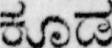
ಕೂಡ
